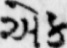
એક
